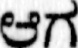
ಆಗ
